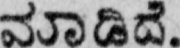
ಮಾಡಿದೆ.
